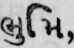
ભુમિ,
